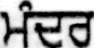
ਮੰਦਰ
